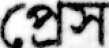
প্রেস
